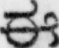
ಈ
